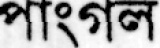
পাংগল
